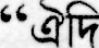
“ঐদি
